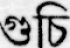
গুচি
